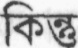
কিন্তু
